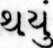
થયું
